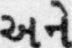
અને
